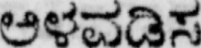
ಅಳವಡಿಸ
